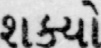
શક્યો
